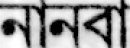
নানবা
